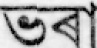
ভৰা
